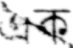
এক
